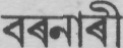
বৰনাৰী
